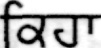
ਕਿਹਾ
